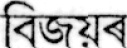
বিজয়ৰ
